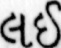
લઈ
